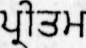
ਪ੍ਰੀਤਮ
